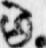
છે.
